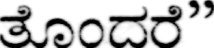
ತೊಂದರೆ"
